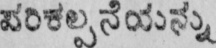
ಪರಿಕಲ್ಪನೆಯನ್ನು
